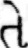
તે
